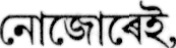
নোজোৰেই,
